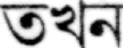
তখন
